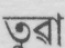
তুৱা
